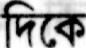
দিকে
